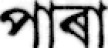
পাৰা
